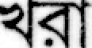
খরা
